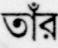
তাঁর
